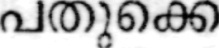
പതുക്കെ
